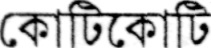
কোটিকোটি
